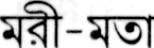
মরী-মতা
